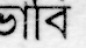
ভাবি
